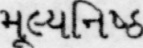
મૂલ્યનિષ્ઠ
